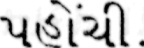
પહોંચી.
